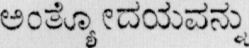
ಅಂತ್ಯೋದಯವನ್ನು
